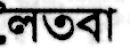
লৈতবা
